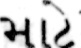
માટે
